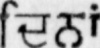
ਦਿਨਾਂ
